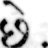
છે.
